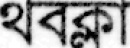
থবক্লা
